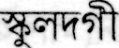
স্কুলদগী
